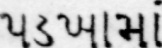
પડખામાં
